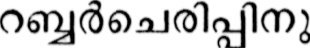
റബ്ബര്‍ചെരിപ്പിനു
